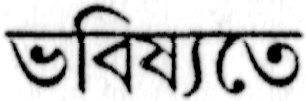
ভবিষ্যতে
